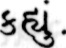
કહ્યું.
